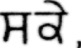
ਸਕੇ,
